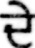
ਦੇ
